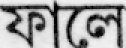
ফালে
